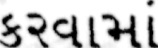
કરવામાં
